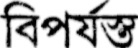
বিপর্যস্ত
